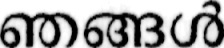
ഞങ്ങള്‍
